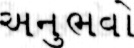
અનુભવો
